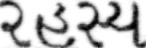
રહસ્ય
